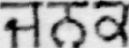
ਜਨਕ
